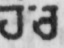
ਹਰ
